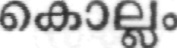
കൊല്ലം
